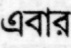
এবার
